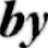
by
